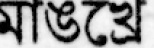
মাঙখ্রে
